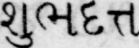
શુભદત્ત
